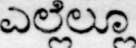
ಎಲ್ಲೆಲ್ಲೂ
